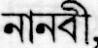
নানবী,
